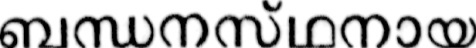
ബന്ധനസ്ഥനായ
